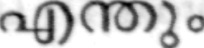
എന്തും
